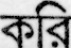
করি
